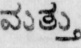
ಮತ್ತು
